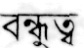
বন্ধুত্ব
